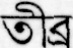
তীব্র
